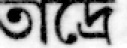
তাদ্রে
